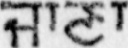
ਜਾਣਾ
